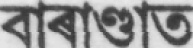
বাৰাণ্ডাত
